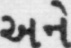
અને
